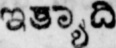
ಇತ್ಯಾದಿ
